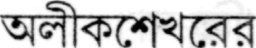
অলীকশেখরের
